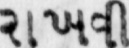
રાખવી
